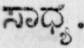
ಸಾಧ್ಯ.
